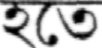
হতে
